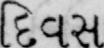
દિવસ
